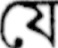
যে
